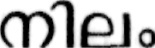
നിലം
